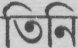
তিনি
